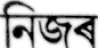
নিজৰ
